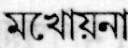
মখোয়না
